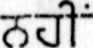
ਨਹੀਂ
